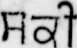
ਸਕੀ
